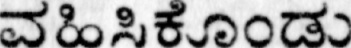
ವಹಿಸಿಕೊಂಡು
